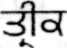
ਤ੍ਰੀਕ
